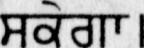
ਸਕੇਗਾ।
